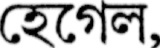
হেগেল,
